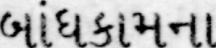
બાંધકામના
